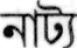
নাট্য
